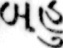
બહુ
